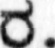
ರ.
